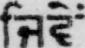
ਜਿਵੇਂ
